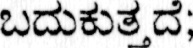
ಬದುಕುತ್ತದೆ;
